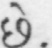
છે.
